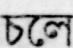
চলে
